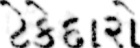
ટેકેદારો
